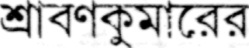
শ্রাবণকুমারের
